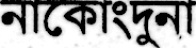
নাকোংদুনা
